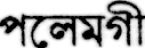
পলেমগী
